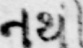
નથી
